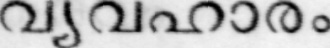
വ്യവഹാരം
